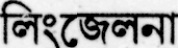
লিংজেলনা
